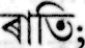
ৰাতি;
